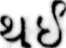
થઈ
